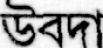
উবদা
